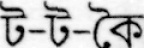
ট-ট-কৈ
